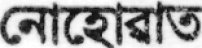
নোহোৱাত
